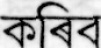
কৰিব
